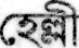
হেল্লী
